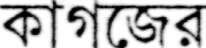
কাগজের
